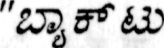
“ಬ್ಯಾಕ್ಟು
